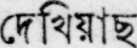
দেখিয়াছ
